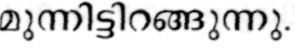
മുന്നിട്ടിറങ്ങുന്നു.
